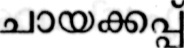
ചായക്കപ്പ്
